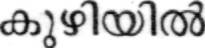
കുഴിയില്‍
